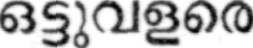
ഒട്ടുവളരെ
